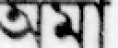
অমা
